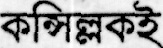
কন্সিল্লকই
